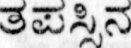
ತಪಸ್ಸಿನ
